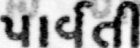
પાર્વતી
